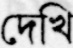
দেখি
